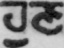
ਹੁਣ
